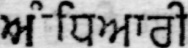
ਅੰਧਿਆਰੀ
